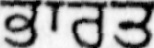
ਭਾਰਤ
